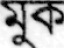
মুক
